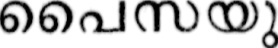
പൈസയു
